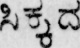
ಸಿಕ್ಕದ
